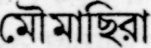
মৌমাছিরা
